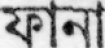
ফানা
